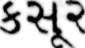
કસૂર
